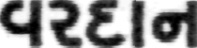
વરદાન
